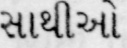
સાથીઓ
